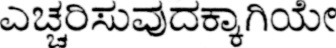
ಎಚ್ಚರಿಸುವುದಕ್ಕಾಗಿಯೇ
